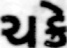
ચક્રે
